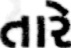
તારે
